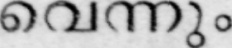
വെന്നും
